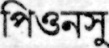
পিওনসু
